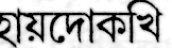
হায়দোকখি
